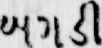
બગડી
